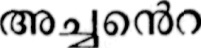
അച്ചന്റെ
